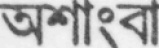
অশাংবা
